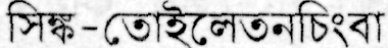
সিঙ্ক-তোইলেতনচিংবা
